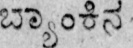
ಬ್ಯಾಂಕಿನ
